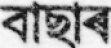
বাছাৰ
